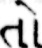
તો
